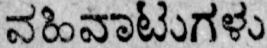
ವಹಿವಾಟುಗಳು
